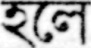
হলে
